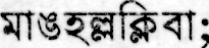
মাঙহল্লক্লিবা;
